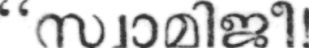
"സ്വാമിജീ!
